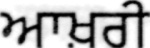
ਆਖ਼ਰੀ
